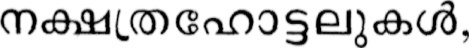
നക്ഷത്രഹോട്ടലുകള്‍,
